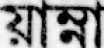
য়াম্না
